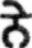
ਨੇ
